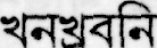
খনখ্রবনি
